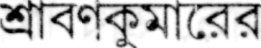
শ্রাবণকুমারের
